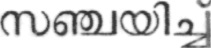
സഞ്ചയിച്ച്
